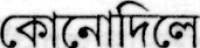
কোনোদিলে
